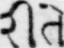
રીતે
